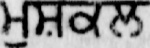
ਮੁਸ਼ਕਲ
